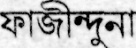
ফাজীন্দুনা
